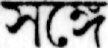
সঙ্গে
